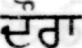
ਦੌਰਾ
